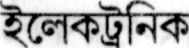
ইলেকট্রনিক
